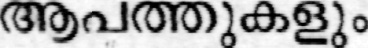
ആപത്തുകളും
